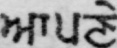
ਆਪਣੇ
